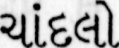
ચાંદલો
